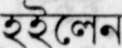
হইলেন
